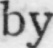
by
